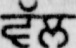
ਵੱਲ
